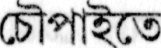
চৌপাইতে
